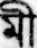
মী
